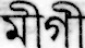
মীগী
